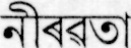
নীৰৱতা
